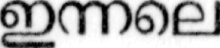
ഇന്നലെ
